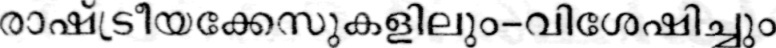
രാഷ്ട്രീയക്കേസുകളിലും-വിശേഷിച്ചും
